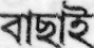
বাছাই
